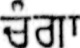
ਚੰਗਾ
